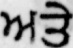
ਅਤੇ
